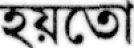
হয়তো
